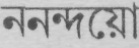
ননন্দয়ো
